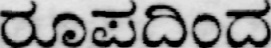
ರೂಪದಿಂದ
